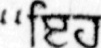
''ਇਹ
